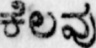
ಕೆಲವು
